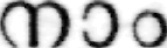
നാം
